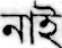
নাই
